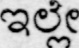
ಇಲ್ಲೇ
